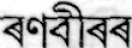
ৰণবীৰৰ
